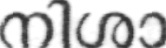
നിശാ
